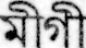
মীগী
